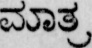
ಮಾತ್ರ
